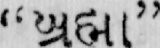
“બ્રહ્મા”
